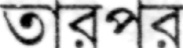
তারপর
